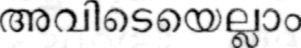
അവിടെയെല്ലാം
